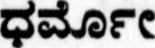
ಧರ್ಮೋ
